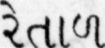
રેતાળ
